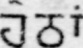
ਹੇਠਾਂ
